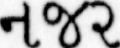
નજર
